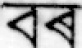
বৰ
